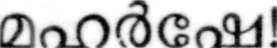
മഹര്‍ഷേ!
